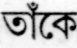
তাঁকে
